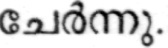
ചേര്‍ന്നു.
